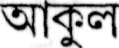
আকুল
